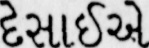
દેસાઈએ
